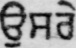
ਉਸਰੇ
